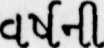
વર્ષની
